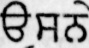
ਉਸਨੇ
